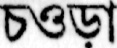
চওড়া
